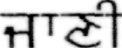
ਜਾਣੀ
